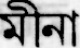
মীনা
